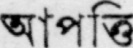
আপত্তি
